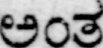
ಅಂತ
